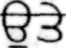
ਉਤੇ
